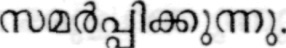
സമര്‍പ്പിക്കുന്നു.
